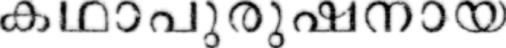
കഥാപുരുഷനായ
